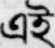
এই
